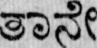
ತಾನೇ
